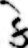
કે
